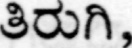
ತಿರುಗಿ,
